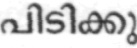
പിടിക്കു
